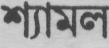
শ্যামল
